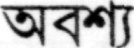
অবশ্য
